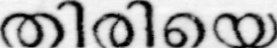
തിരിയെ
